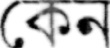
কেন
